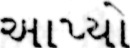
આપ્યો
